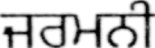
ਜਰਮਨੀ
